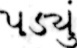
પડ્યું
